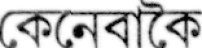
কেনেবাকৈ
